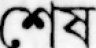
শেষ
